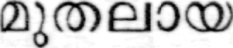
മുതലായ
